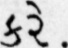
કરે.
